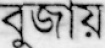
বুজায়
